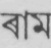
ৰাম
